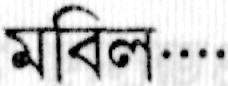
মবিল....
